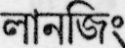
লানজিং
